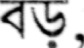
বড়,
